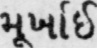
મૂર્ખાઈ
